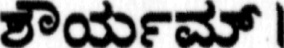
ಶೌರ್ಯಮ್|
